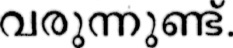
വരുന്നുണ്ട്.
